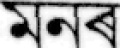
মনৰ
